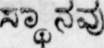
ಸ್ಥಾನವು
